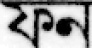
ফন
